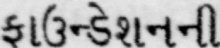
ફાઉન્ડેશનની
